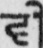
ਵੀ
